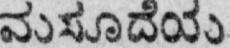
ಮಸೂದೆಯ
